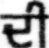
ਦੀ
